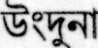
উংদুনা
